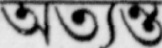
অত্যন্ত
